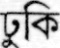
ঢুকি
